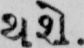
થશે.
